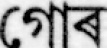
গোৰ
